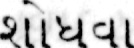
શોધવા
